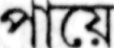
পায়ে
